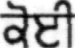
ਕੋਈ
